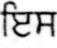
ਇਸ
